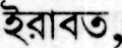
ইরাবত,
